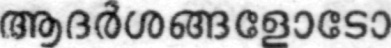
ആദര്‍ശങ്ങളോടോ
